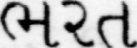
ભરત
